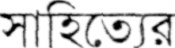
সাহিত্যের
